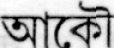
আকৌ
